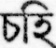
চহি
